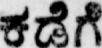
ಕಡೆಗೆ
